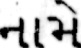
નામે
